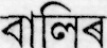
বালিৰ
